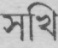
সখি
